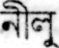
নীলু
